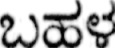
ಬಹಳ
